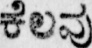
ಕೆಲವು
